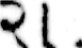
રા.
